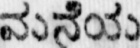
ಮನೆಯ
